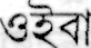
ওইবা
